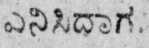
ಎನಿಸಿದಾಗ
